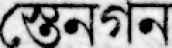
স্তেনগন
